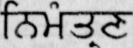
ਨਿਮੰਤ੍ਰਣ
